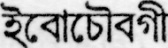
ইবোচৌবগী
